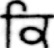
ਕਿ
